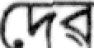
দেৱ
